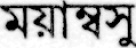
ময়াম্বসু
